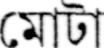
মোটা
